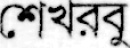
শেখরবু
